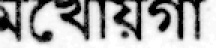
মখোয়গা
